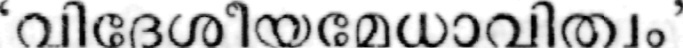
'വിദേശീയമേധാവിത്വം'
